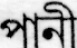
পানী
